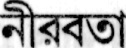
নীরবতা
